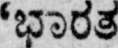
‘ಭಾರತ
